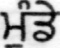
ਮੁੰਡੇ
